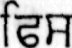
ਫਿਸ
